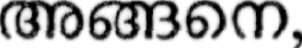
അങ്ങനെ,
